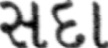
સદા
